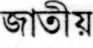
জাতীয়
